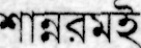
শান্নরমই
